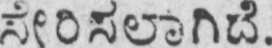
ಸೇರಿಸಲಾಗಿದೆ.
